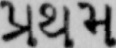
પ્રથમ
